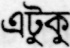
এটুকু
